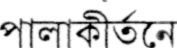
পালাকীর্তনে
